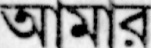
আমার
